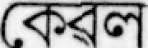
কেৱল
